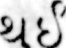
થઈ
